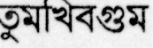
তুমখিবগুম
